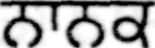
ਨਾਨਕ
